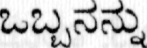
ಒಬ್ಬನನ್ನು
